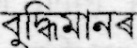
বুদ্ধিমানৰ
